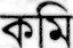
কমি
